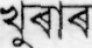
খুৰাৰ
